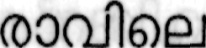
രാവിലെ
